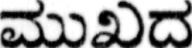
ಮುಖದ
